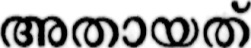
അതായത്
